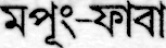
মপূং-ফাবা
